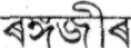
ৰঙ্গজীৰ
